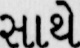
સાથે
